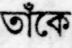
তাঁকে
